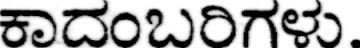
ಕಾದಂಬರಿಗಳು.
